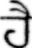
ਹੈ
